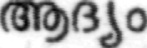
ആദ്യം
